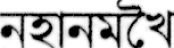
নহানমখৈ
